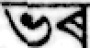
ভৰ
